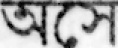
অসে
